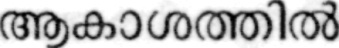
ആകാശത്തില്‍
